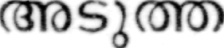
അടുത്ത
